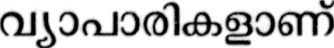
വ്യാപാരികളാണ്
